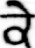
ਕੇ
